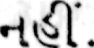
નહીં.
